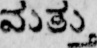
ಮತ್ತು
